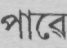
পাৱে
